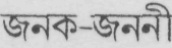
জনক-জননী
